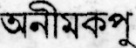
অনীমকপু
